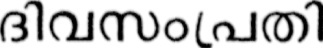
ദിവസംപ്രതി
